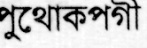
পুথোকপগী
